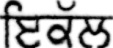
ਇਕੱਲ
